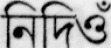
নিদিওঁ
